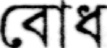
বোধ
